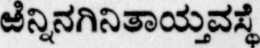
ಱನ್ನಿನಗಿನಿತಾಯ್ತವಸ್ಥೆ
